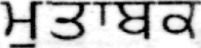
ਮੁਤਾਬਕ
